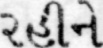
રહીને
